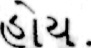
હોય.
